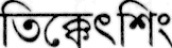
তিক্কেৎশিং
